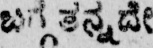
ಬಗ್ಗೆತನ್ನದೇ
